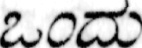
ಒಂದು
